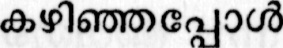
കഴിഞ്ഞപ്പോള്‍
